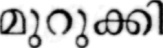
മുറുക്കി
